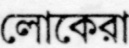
লোকেরা
